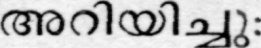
അറിയിച്ചു:
